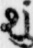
શું
